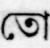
তো
